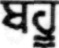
ਬਹੂ
